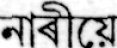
নাৰীয়ে
